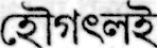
হৌগৎলকই
